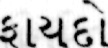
ફાયદો
